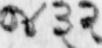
જરૂર
